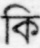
কি
